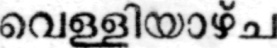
വെള്ളിയാഴ്ച
